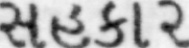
સહકાર
